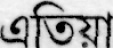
এতিয়া
